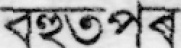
বহুতপৰ
